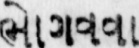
ભોગવવા
